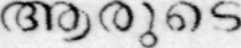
ആരുടെ
